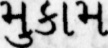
મુકામ
